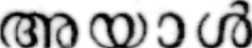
അയാള്‍
